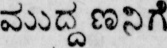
ಮುದ್ದಣನಿಗೆ
